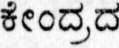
ಕೇಂದ್ರದ
